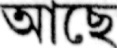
আছে
